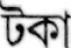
টকা
